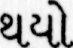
થયો
